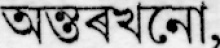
অন্তৰখনো,
